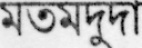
মতমদুদা
